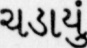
ચડાયું
